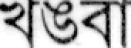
খঙবা
